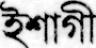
ইশাগী
